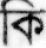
কি
